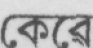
কেৱে
